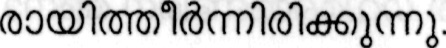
രായിത്തീര്‍ന്നിരിക്കുന്നു.
